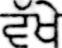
ਵੱਖੇ
